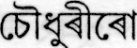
চৌধুৰীৰো
